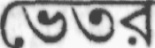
ভেতর
